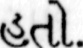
હતો.
